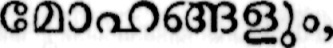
മോഹങ്ങളും,
